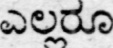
ಎಲ್ಲರೂ
